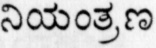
ನಿಯಂತ್ರಣ
